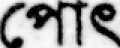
পোৎ
